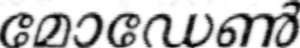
മോഡേണ്‍
